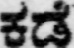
ಕಡೆ
